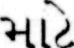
માટે
